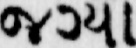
જગ્યા
